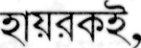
হাইরকই,
